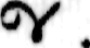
જ.
